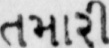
તમારી
